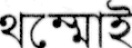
থম্মোই
